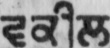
ਵਕੀਲ
